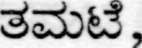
ತಮಟೆ,
